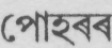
পোহৰৰ
